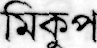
মিকুপ
